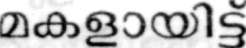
മകളായിട്ട്
